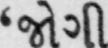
'જોગી
